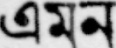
এমন
